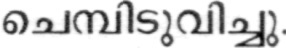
ചെമ്പിടുവിച്ചു.
